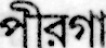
পীরগা
